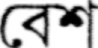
বেশ
